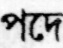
পদে
